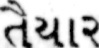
તૈયાર
